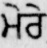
ਮੇਰੇ
